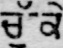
ਚੁੱਕੇ
